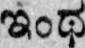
ಇಂಥ
